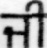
ਜੀ
